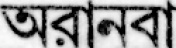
অরানবা
